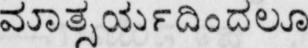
ಮಾತ್ಸರ್ಯದಿಂದಲೂ
